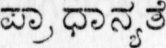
ಪ್ರಾಧಾನ್ಯತೆ
